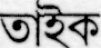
তাইক
